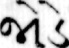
જોડે
